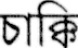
চাক্কি
